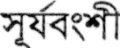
সূর্যবংশী
